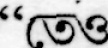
"তেও
